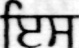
ਇਸ
